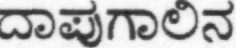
ದಾಪುಗಾಲಿನ
